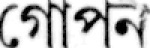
গোপন
